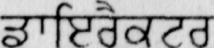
ਡਾਇਰੈਕਟਰ
